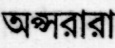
অপ্সরারা
